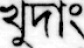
খুদাং
